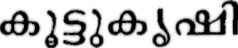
കൂട്ടുകൃഷി
